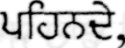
ਪਹਿਨਦੇ,
